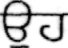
ਉਹ
